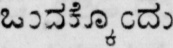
ಒಂದಕ್ಕೊಂದು
